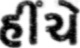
હીચે
